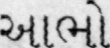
આભો
